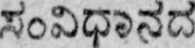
ಸಂವಿಧಾನದ
